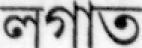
লগাত
